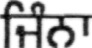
ਜਿੰਨਾ
